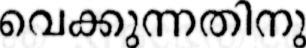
വെക്കുന്നതിനു
